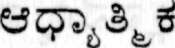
ಆಧ್ಯಾತ್ಮಿಕ
